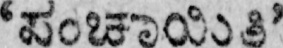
‘ಪಂಚಾಯಿತಿ’
